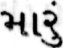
મારું
